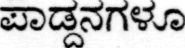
ಪಾಡ್ದನಗಳೂ
